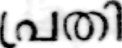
പ്രതി
